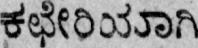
ಕಛೇರಿಯಾಗಿ
